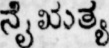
ನೈಋತ್ಯ
